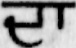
ਦਾ
